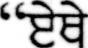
''ਏਥੇ
